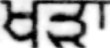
ਖੜਾ
